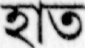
হাত
